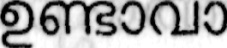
ഉണ്ടാവാ
